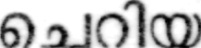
ചെറിയ
